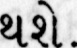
થશે.
